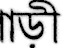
গাড়ী
